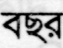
বছর
